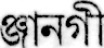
ঞ্জানগী
